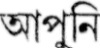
আপুনি
